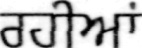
ਰਹੀਆਂ
